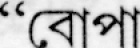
"বোপা
